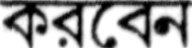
করবেন
